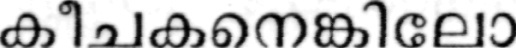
കീചകനെങ്കിലോ
